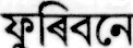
ফুৰিবনে
